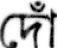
দোঁ
